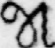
જા
